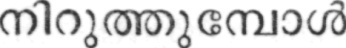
നിറുത്തുമ്പോള്‍
